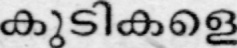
കുടികളെ
